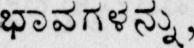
ಭಾವಗಳನ್ನು,
